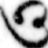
ও
